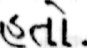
હતો.
